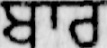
ਬਾਰ
